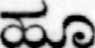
ಹೂ
